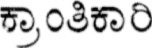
ಕ್ರಾಂತಿಕಾರಿ
